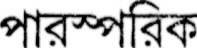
পারস্পরিক
